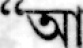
“আ
